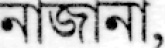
নাজানা,
